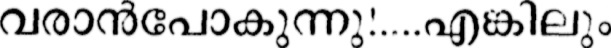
വരാന്‍പോകുന്നു!....എങ്കിലും
